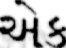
એક
